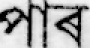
পাৰ
